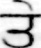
ਤੇ
